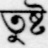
তুষ্ট
